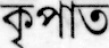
কৃপাত
